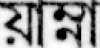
য়াম্না
